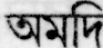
অমদি
